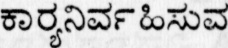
ಕಾರ್ಯನಿರ್ವಹಿಸುವ
